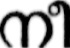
നീ
